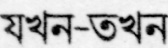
যখন-তখন
